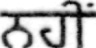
ਨਹੀਂ
